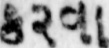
કરવા
